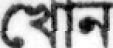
খোন
